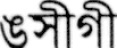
ঙসীগী
